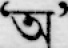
'অ'
